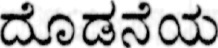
ದೊಡನೆಯ
